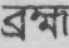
ব্ৰহ্ম
